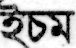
ইচম
